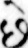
છે
